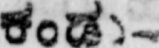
ಕಂಡು-
